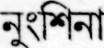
নুংশিনা
